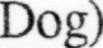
Dog)
